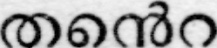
തന്റെ
